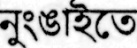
নুংঙাইতে
